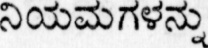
ನಿಯಮಗಳನ್ನು
